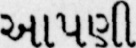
આપણી
